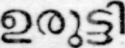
ഉരുട്ടി
